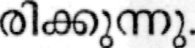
രിക്കുന്നു.
